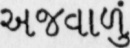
અજવાળું
